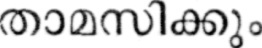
താമസിക്കും
